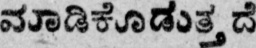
ಮಾಡಿಕೊಡುತ್ತದೆ
